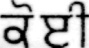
ਕੋਈ
